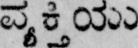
ವ್ಯಕ್ತಿಯು
